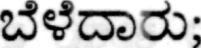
ಬೆಳೆದಾರು;
